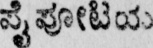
ಪೈಪೋಟಿಯ
